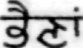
ਭੈਣਾਂ
